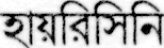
হায়রিসিনি
